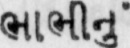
ભાભીનું
